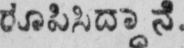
ರೂಪಿಸಿದ್ದಾನೆ.
